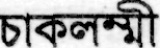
চাকলম্মী
